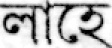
লাহে
